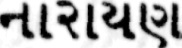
નારાયણ
